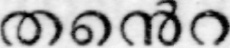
തന്റെ
